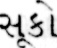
સૂકો
